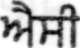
ਐਸੀ
